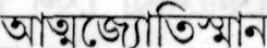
আত্মজ্যোতিস্মান
